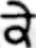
ਕੇ
